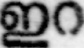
ഇറ
